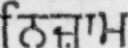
ਨਿਜ਼ਾਮ
